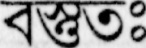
বস্তুতঃ
